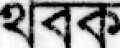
থবক
